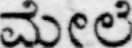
ಮೇಲೆ
